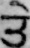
ਤੇ
